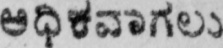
ಅಧಿಕವಾಗಲು
